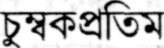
চুম্বকপ্রতিম
